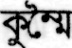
কুম্মৈ
